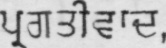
ਪ੍ਰਗਤੀਵਾਦ,
